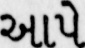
આપે
